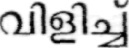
വിളിച്ച്
